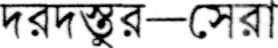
দরদস্তুর–সেরা
